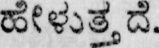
ಹೇಳುತ್ತದೆ.
